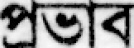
প্রভাব
